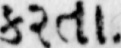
કરતા.
